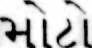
મોટો
